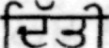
ਦਿੱਤੀ
